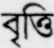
বৃত্তি
